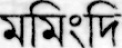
মমিংদি
